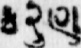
કરુણ
